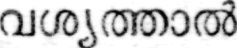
വശ്യത്താല്‍
